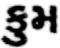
કુમ
